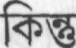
কিন্তু
